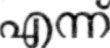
എന്ന്
